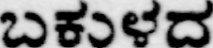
ಬಕುಳದ
